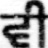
ਵੀ
